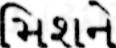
મિશને
